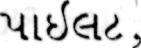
પાઇલટ,
